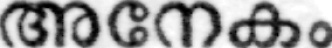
അനേകം
